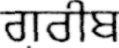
ਗ਼ਰੀਬ
